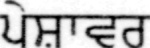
ਪੇਸ਼ਾਵਰ
